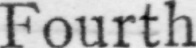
Fourth
